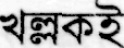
খল্লকই
